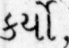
કર્યો,
